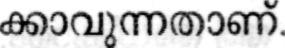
ക്കാവുന്നതാണ്.
